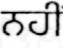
ਨਹੀਂ
